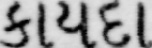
કાયદા
